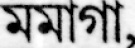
মমাগা,
